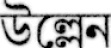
উল্লেন
